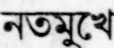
নতমুখে
